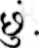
છું.
